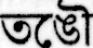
তঙৌ
